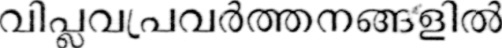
വിപ്ലവപ്രവര്‍ത്തനങ്ങളില്‍
